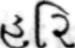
હરિ
